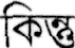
কিন্তু
